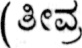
(ತೀವ್ರ
